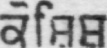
ਕੋਸ਼ਿਸ਼
